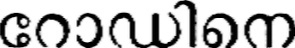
റോഡിനെ
